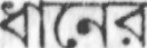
ধানের
